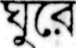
ঘুরে
